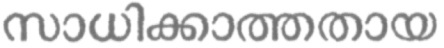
സാധിക്കാത്തതായ
